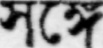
সঙ্গে
